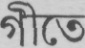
গীতে
